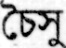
চৈসু
